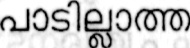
പാടില്ലാത്ത
